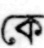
কে
